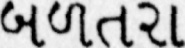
બળતરા
